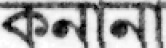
কনানা
